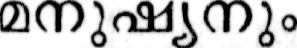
മനുഷ്യനും
